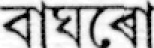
বাঘৰো
